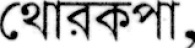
থোরকপা,
